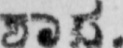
ಶಾಪ.
